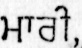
ਮਾਰੀ,
